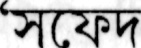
‘সফেদ
